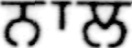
ਨਾਲ
